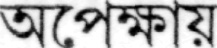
অপেক্ষায়
